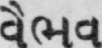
વૈભવ
